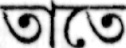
তাতে
